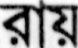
রায়
